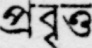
প্রবৃত্ত
